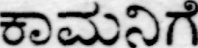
ಕಾಮನಿಗೆ
